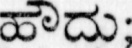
ಹೌದು;
